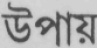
উপায়
